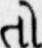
તો
